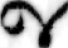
જ
